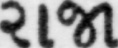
રાજા
